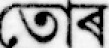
তোৰ
